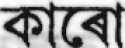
কাৰো
